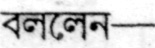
বললেন–
